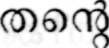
തന്റെ
